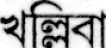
খল্লিবা
